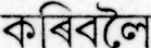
কৰিবলৈ
